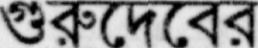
গুরুদেবের
